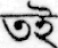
তই
